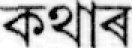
কথাৰ
